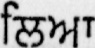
ਲਿਆ
